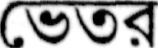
ভেতর
